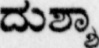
ದುಶ್ಯಾ
